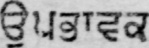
ਉਪਭਾਵਕ
